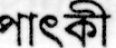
পাৎকী
